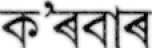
ক'ৰবাৰ
